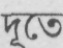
দূতে
